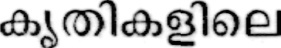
കൃതികളിലെ
